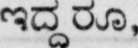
ಇದ್ದರೂ,
